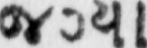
જગ્યા
